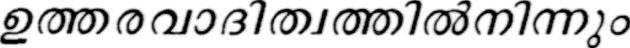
ഉത്തരവാദിത്വത്തില്‍നിന്നും
